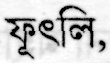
হয়েং
